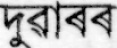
দুৱাৰৰ
